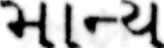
માન્ય
